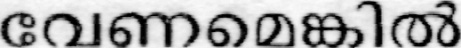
വേണമെങ്കില്‍
